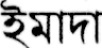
ইমাদা
